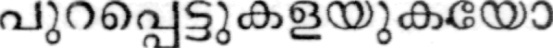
പുറപ്പെട്ടുകളയുകയോ
